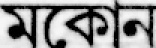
মকোন
